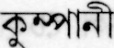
কুম্পানী
